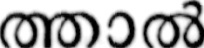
ത്താല്‍
